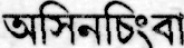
অসিনচিংবা
